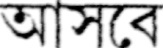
আসবে
